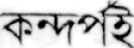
কন্দর্পই
